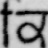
ਕਿ
